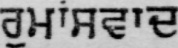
ਰੁਮਾਂਸਵਾਦ
